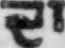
ਦਾ
